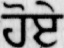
ਹੋਏ
